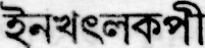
ইনখৎলকপী
